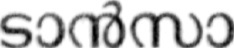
ടാന്‍സാ
